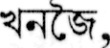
খনজৈ,
